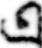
এ
